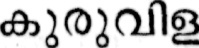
കുരുവിള
